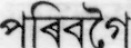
পৰিবগৈ
